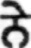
ਨੇ
